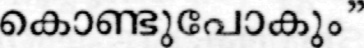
കൊണ്ടുപോകും”
